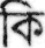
কি
